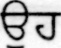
ਉਹ
